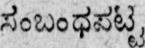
ಸಂಬಂಧಪಟ್ಟ
